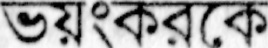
ভয়ংকরকে
